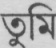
তুমি
